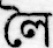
লৈ
